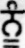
ਨੂੰ
